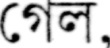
গেল,
